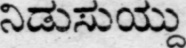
ನಿಡುಸುಯ್ದು
